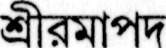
শ্রীরমাপদ
